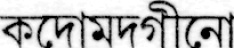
কদোমদগীনো
